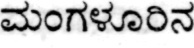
ಮಂಗಳೂರಿನ
